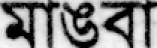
মাঙবা
